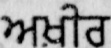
ਅਖ਼ੀਰ
